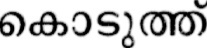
കൊടുത്ത്
